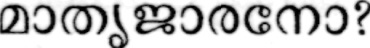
മാതൃജാരനോ?
